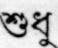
শুধু
